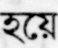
হয়ে
